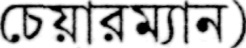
চেয়ারম্যান)
